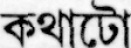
কথাটো
